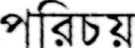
পরিচয়
